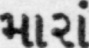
મારાં
